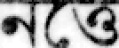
নত্তে
